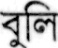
বুলি
